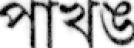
পাখঙ
